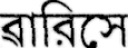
ৱারিসে
